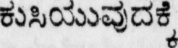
ಕುಸಿಯುವುದಕ್ಕೆ
